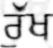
ਰੁੱਖ
